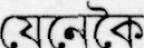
যেনেকৈ
